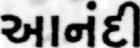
આનંદી
